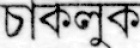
চাকলুক
